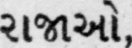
રાજાઓ,
